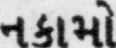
નકામો
